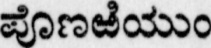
ಪೊಣಱಯುಂ
